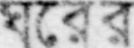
ঘরের
